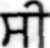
ਸੀ
